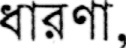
ধারণা,
